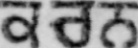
ਕਰਨ
